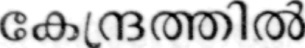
കേന്ദ്രത്തില്‍
